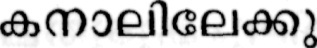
കനാലിലേക്കു
